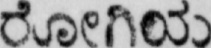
ರೋಗಿಯ
